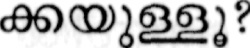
ക്കയുള്ളൂ?
